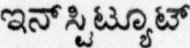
ಇನ್‌ಸ್ಟಿಟ್ಯೂಟ್
